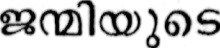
ജന്മിയുടെ
